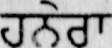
ਹਨੇਰਾ
